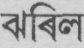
ঝৰিল
